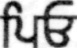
ਪਿਓ
